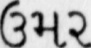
ઉમર
